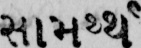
સામર્થ્થ
